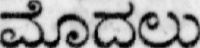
ಮೊದಲು
